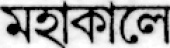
মহাকালে
